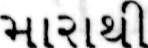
મારાથી
